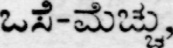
ಒಸೆ-ಮೆಚ್ಚು,
